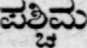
ಪಶ್ಚಿಮ
